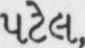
પટેલ,
